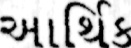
આર્થિક
